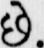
છે.
